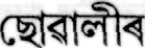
ছোৱালীৰ
